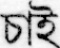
চাই
